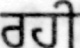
ਰਹੀ
